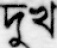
দুখ
